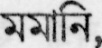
মমানি,
